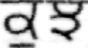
ਕੁਝ
